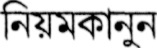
নিয়মকানুন
